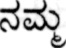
ನಮ್ಮ
